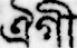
ঐগী
